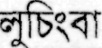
লুচিংবা
